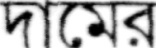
দামের
